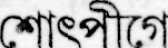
শোৎপীগে
